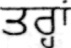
ਤਰ੍ਹਾਂ
